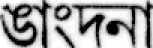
ঙাংদনা
